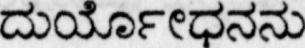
ದುರ್ಯೋಧನನು
